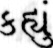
કહ્યું
